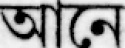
আনে
